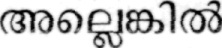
അല്ലെങ്കില്‍
